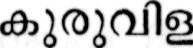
കുരുവിള
